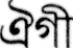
ঐগী
